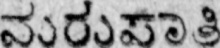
ಮರುಪಾತಿ
